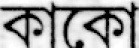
কাকো
